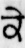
ਕੇ
